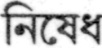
নিষেধ
